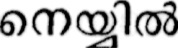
നെയ്യില്‍
